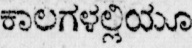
ಕಾಲಗಳಲ್ಲಿಯೂ
